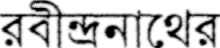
রবীন্দ্রনাথের
